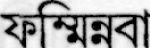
ফম্মিন্নবা
